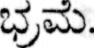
ಭ್ರಮೆ.
